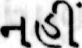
નહીં
